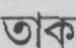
তাক
